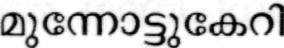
മുന്നോട്ടുകേറി
